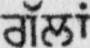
ਗੱਲਾਂ
